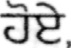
ਹੋਏ,
